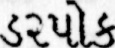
ડરપોક
